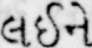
લઈને
